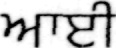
ਆਈ
